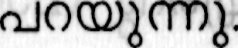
പറയുന്നു.
